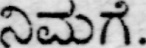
ನಿಮಗೆ.
